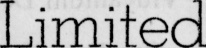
Limited
